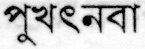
পুখৎনবা
